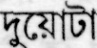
দুয়োটা
